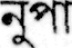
নুপা
